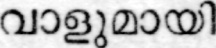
വാളുമായി
